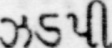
ઝડપી
